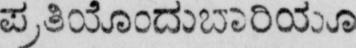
ಪ್ರತಿಯೊಂದುಬಾರಿಯೂ
